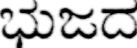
ಭುಜದ
